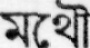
মথৌ
